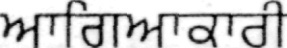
ਆਗਿਆਕਾਰੀ
